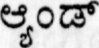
ಅಂಡ್
